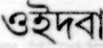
ওইদবা
